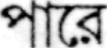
পারে
